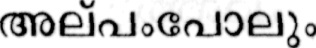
അല്പംപോലും
